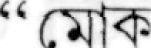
"মোক
